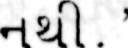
નથી.'
